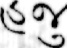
હજુ
